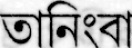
তানিংবা
